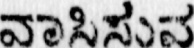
ವಾಸಿಸುವ
